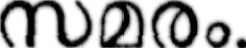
സമരം.
